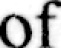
of
